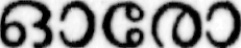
ഓരോ
